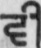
ਵੀ
